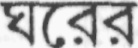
ঘরের
